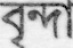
বৃন্দা
